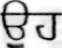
ਉਹ
